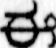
ಈ
